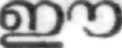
ഈ
